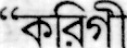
“করিগী
